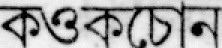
কওকচোন
